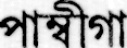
পাম্বীগা
